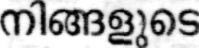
നിങ്ങളുടെ
